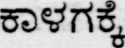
ಕಾಳಗಕ್ಕೆ
